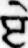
ਏ
